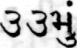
33મું
